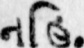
નહિ.
